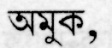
অমুক,
